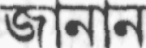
জানান
